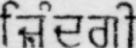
ਜ਼ਿੰਦਗੀ
